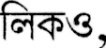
লিকও,
